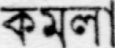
কমলা
